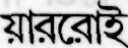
য়াররোই
